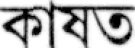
কাষত
